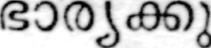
ഭാര്യക്കു
